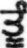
ਤੂੰ
